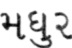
મધુર
